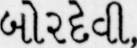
બોરદેવી
